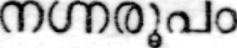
നഗ്നരൂപം
